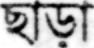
ছাড়া
